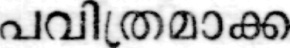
പവിത്രമാക്ക
